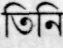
তিনি
